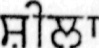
ਸ਼ੀਲਾ
